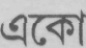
একো
